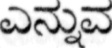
ಎನ್ನುವ
